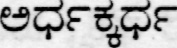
ಅರ್ಧಕ್ಕರ್ಧ
